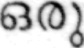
ഒരു
